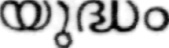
യുദ്ധം
